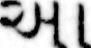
આ
